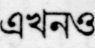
এখনও
